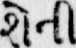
શેની?
